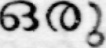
ഒരു
